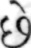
છે
